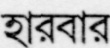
হারবার
